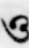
ও
